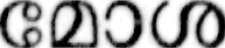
മോശ
